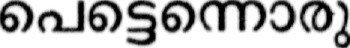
പെട്ടെന്നൊരു
